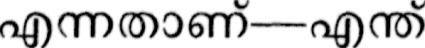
എന്നതാണ്-എന്ത്
